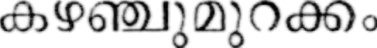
കഴഞ്ചുമുറക്കം
